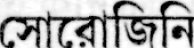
সোরোজিনি
